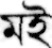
মই
